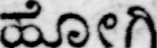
ಹೋಗಿ
